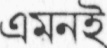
এমনই
